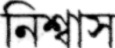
নিশ্বাস
